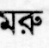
মরু
